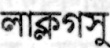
লাক্লগসু
